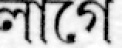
লাগে
